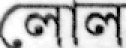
লোল
